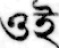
ওই
